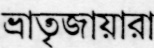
ভ্রাতৃজায়ারা
